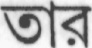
তার
